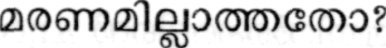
മരണമില്ലാത്തതോ?
